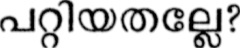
പറ്റിയതല്ലേ?
